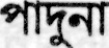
পাদুনা
